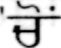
'ਚੋਂ
